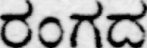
ರಂಗದ
